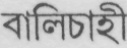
বালিচাহী
